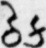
ઠેક
